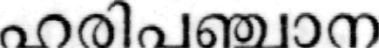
ഹരിപഞ്ചാന
